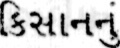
કિસાનનું
